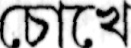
চোখে
